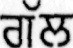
ਗੱਲ
